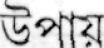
উপায়
